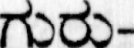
ಗುರು-
